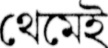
থেমেই
